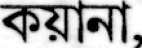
কয়ানা,
